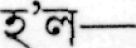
হ'ল-
